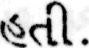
હતી.
